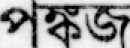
পঙ্কজ
